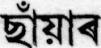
ছাঁয়াৰ
